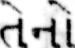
તેનો
